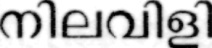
നിലവിളി
